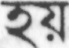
হয়
